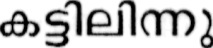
കട്ടിലിന്നു
